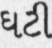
ઘટી
